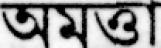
অমত্তা
